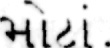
મોટાં.
